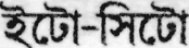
ইটো-সিটো
